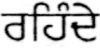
ਰਹਿੰਦੇ
